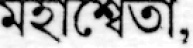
মহাশ্বেতা,
